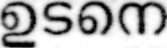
ഉടനെ
